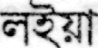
লইয়া
